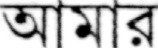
আমার
